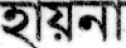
হায়না
